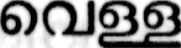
വെള്ള
